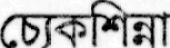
চ্যেকশিন্না
